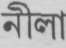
নীলা
